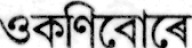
ওকণিবোৰে
